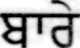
ਬਾਰੇ
